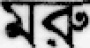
মরু
